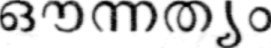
ഔന്നത്യം
